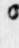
યે
